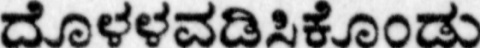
ದೊಳಳವಡಿಸಿಕೊಂಡು
